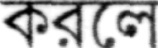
করলে
